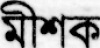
মীশক
